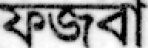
ফজবা
